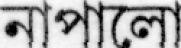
নাপালো
